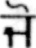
ਜੋ
